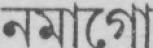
নমাগো
